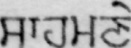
ਸਾਹਮਣੇ
